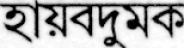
হায়বদুমক
